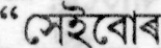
"সেইবোৰ
